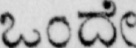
ಒಂದೇ
